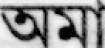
অমা
